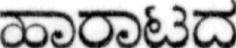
ಹಾರಾಟದ
